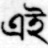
এই
